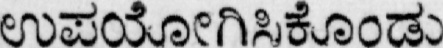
ಉಪಯೋಗಿಸಿಕೊಂಡು
